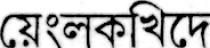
য়েংলকখিদে
